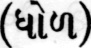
(ધોળ)
